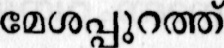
മേശപ്പുറത്ത്
